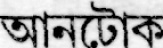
আনটোক
